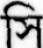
সি
